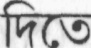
দিতে
